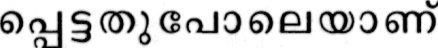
പ്പെട്ടതുപോലെയാണ്
